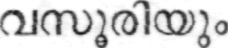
വസൂരിയും
